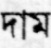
দাম
